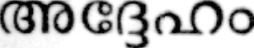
അദ്ദേഹം
